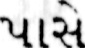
પાસે
